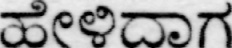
ಹೇಳಿದಾಗ
